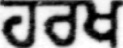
ਹਰਖ
